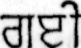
ਗਈ
